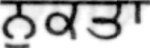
ਨੁਕਤਾ
